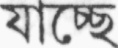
যাচ্ছে
